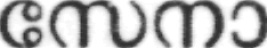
സേനാ
